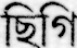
ছিগি
